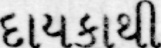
દાયકાથી
